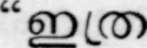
"ഇത്ര
